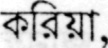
করিয়া,
